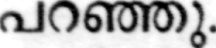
പറഞ്ഞു.
